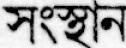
সংস্থান
